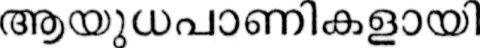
ആയുധപാണികളായി
